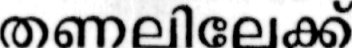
തണലിലേക്ക്
